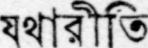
যথারীতি
